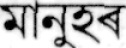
মানুহৰ
